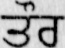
ਤੌਰ
